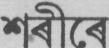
শৰীৰে
